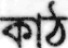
কাঠ
